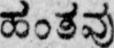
ಹಂತವು
